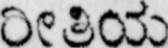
ರೀತಿಯ
